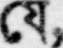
যে,
